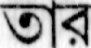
তার
